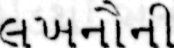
લખનૌની
